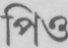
পিও
